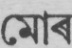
মোৰ
